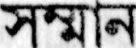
সম্মান
